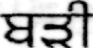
ਬੜੀ
